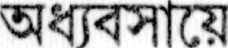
অধ্যবসায়ে
